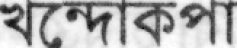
খন্দোকপা
